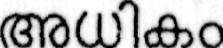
അധികം
